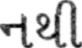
નથી
